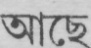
আছে
